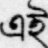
এই
